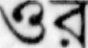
ওর
